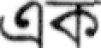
এক
